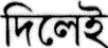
দিলেই
